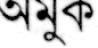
অমুক
